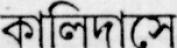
কালিদাসে
